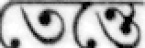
তেন্তে
